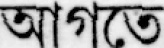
আগতে
